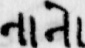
નાનો
